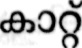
കാറ്റ്
